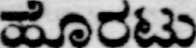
ಹೊರಟು
